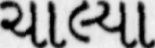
ચાલ્યા
